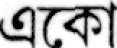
একো
